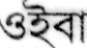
ওইবা
